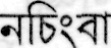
নচিংবা
